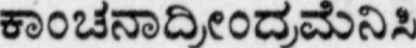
ಕಾಂಚನಾದ್ರೀಂದ್ರಮೆನಿಸಿ
